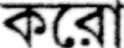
করো
